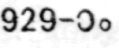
929-ാം
